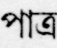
পাত্র
